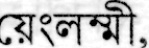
য়েংলম্মী,
